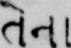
તેના
